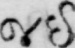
જઈ
